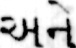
અને
